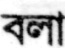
বলা
